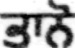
ਭਾਨੋ
